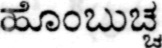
ಹೊಂಬುಚ್ಚ
